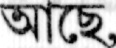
আছে,
